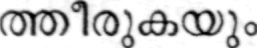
ത്തീരുകയും
